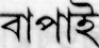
বাপাই
